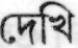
দেখি
